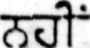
ਨਹੀਂ
